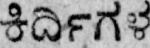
ಕಿರ್ದಿಗಳ
